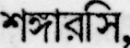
শঙ্গারসি,
